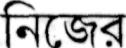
নিজের
